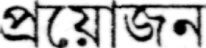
প্রয়োজন
